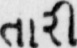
તારી
